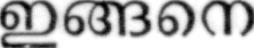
ഇങ്ങനെ
